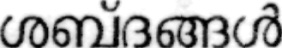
ശബ്ദങ്ങള്‍
